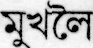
মুখলৈ
